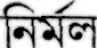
নিৰ্মল
